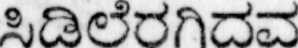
ಸಿಡಿಲೆರಗಿದವ
